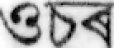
ওচৰ
